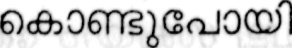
കൊണ്ടുപോയി
